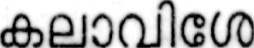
കലാവിശേ
